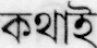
কথাই
